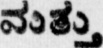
ಮತ್ತು
